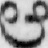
ಆ
